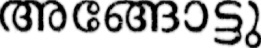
അങ്ങോട്ടു
